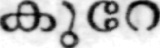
കുറേ
